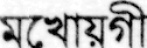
মখোয়গী
